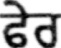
ਫੇਰ
